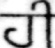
ਹੀ
